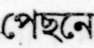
পেছনে
